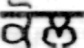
ਕੋਲ
